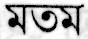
মতম
